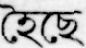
হৈছে
